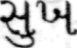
સુખ
